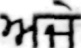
ਅਜੇ
